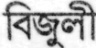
বিজুলী
